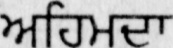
ਅਹਿਮਦਾ
